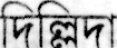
দিল্লিদা
